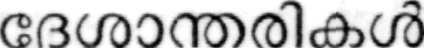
ദേശാന്തരികള്‍
